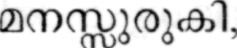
മനസ്സുരുകി,
